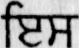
ਇਸ
